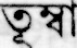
তূম্বা
